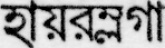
হায়রম্লগা
